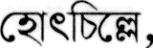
হোৎচিল্লে,
